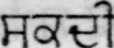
ਸਕਦੀ
